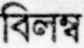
বিলম্ব
